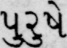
પુરુષે
